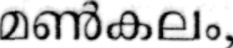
മണ്‍കലം,
